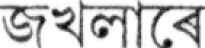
জখলাৰে
